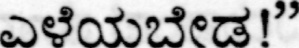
ಎಳೆಯಬೇಡ!"
